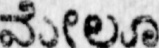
ಮೇಲೂ
